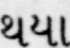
થયા
